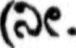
(ನೀ.
